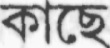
কাছে
